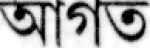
আগত
